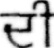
ਦੀ
